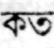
কত
